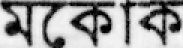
মকোক
